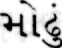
મોઢું
